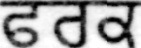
ਫਰਕ
